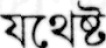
যথেষ্ট
